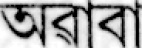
অৱাবা
